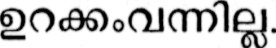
ഉറക്കംവന്നില്ല.
